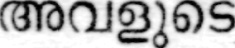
അവളുടെ
